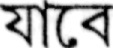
যাবে
